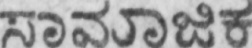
ಸಾಮಾಜಿಕ
